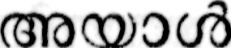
അയാള്‍
